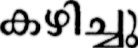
കഴിച്ചു
